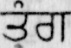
ਤੰਗ
